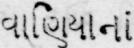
વાણિયાનાં
